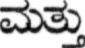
ಮತ್ತು
